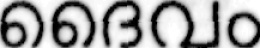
ദൈവം
